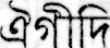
ঐগীদি
